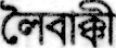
লৈবাক্কী
